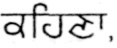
ਕਹਿਣਾ,
